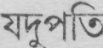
যদুপতি
